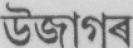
উজাগৰ
